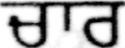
ਚਾਰ
